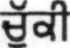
ਚੁੱਕੀ
